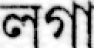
লগা
